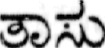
ತಾಸು
